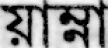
য়াম্না
